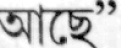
আছে"
